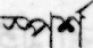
স্পৰ্শ
